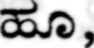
ಹೂ,
